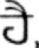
ਹੈ,
